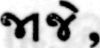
જાજે,
